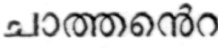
ചാത്തന്റെ
